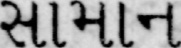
સામાન
